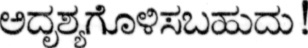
ಅದೃಶ್ಯಗೊಳಿಸಬಹುದು!
